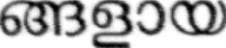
ങ്ങളായ
